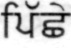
ਪਿੱਛੇ
